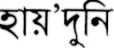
হায়’দুনি
